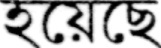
হয়েছে
